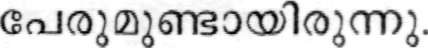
പേരുമുണ്ടായിരുന്നു.
